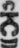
ਨੂੰ
